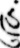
હું
